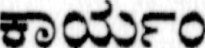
ಕಾರ್ಯಂ
